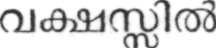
വക്ഷസ്സില്‍
